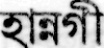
হান্নগী
